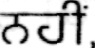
ਨਹੀਂ,
